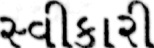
સ્વીકારી
